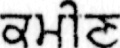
ਕਮੀਣ
